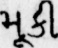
મૂકી
